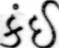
કંઈ
